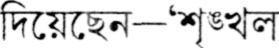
দিয়েছেন–‘শৃঙ্খল
